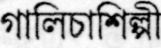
গালিচাশিল্পী
